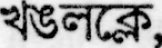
খঙলক্লে,
